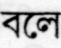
বলে
